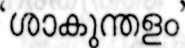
'ശാകുന്തളം'
